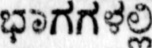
ಭಾಗಗಳಲ್ಲಿ
